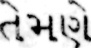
તેમણે
